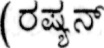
(ರಷ್ಯನ್
